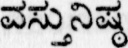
ವಸ್ತುನಿಷ್ಠ
